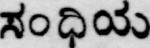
ಸಂಧಿಯ
